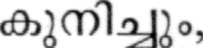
കുനിച്ചും,
